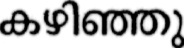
കഴിഞ്ഞു
